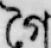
গৈ
